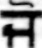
ਜੋ
